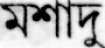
মশাদু
